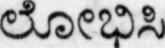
ಲೋಭಿಸಿ
